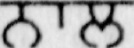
ਨਾਲ
